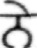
ਨੇ
